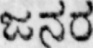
ಜನರ
